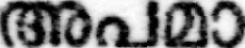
അപമാ
